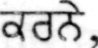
ਕਰਨੇ,
